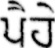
ਪੈਹੇ
